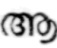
ആ
